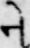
ને
